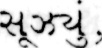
સૂઝયું,
